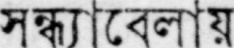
সন্ধ্যাবেলায়
